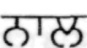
ਨਾਲ
